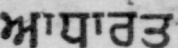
ਆਧਾਰਤ
